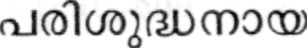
പരിശുദ്ധനായ
